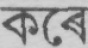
কৰে
